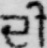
ਦੀ
